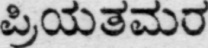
ಪ್ರಿಯತಮರ
